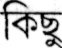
কিছু
